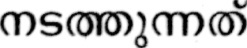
നടത്തുന്നത്
